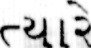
ત્યારે
